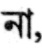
না,
